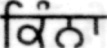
ਕਿੰਨਾ
